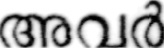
അവര്‍
